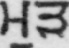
ਮੁੜ
